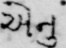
એનું
